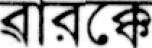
ৱারক্কে
